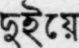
দুইয়ে
